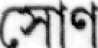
সোণ
